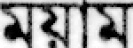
ময়াম
